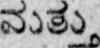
ಮತ್ತು
